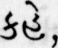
કહે,
